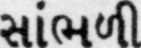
સાંભળી
